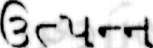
ઉત્પન્ન
